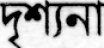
দৃশ্যনা
